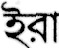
ইরা
